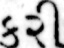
કરી
